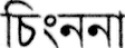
চিংননা
